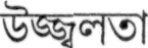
উজ্জ্বলতা
